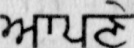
ਆਪਣੇ
